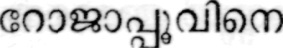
റോജാപ്പൂവിനെ
